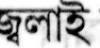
জ্বলাই
